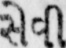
સેવી
